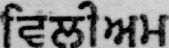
ਵਿਲੀਅਮ
